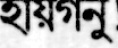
হায়গনু
